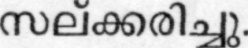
സല്ക്കരിച്ചു.
